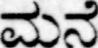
ಮನೆ
